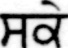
ਸਕੇ
